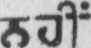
ਨਹੀਂ
